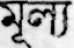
মূল্য
